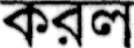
করল
